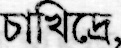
চাখিদ্রে,
